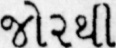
જોરથી
